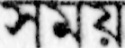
সময়
